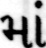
માં
